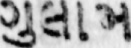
ગુલામ
